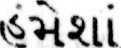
હંમેશાં
